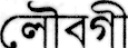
লৌবগী
